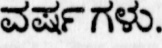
ವರ್ಷಗಳು.
